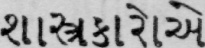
શાસ્ત્રકારોએ
